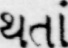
થતાં
